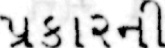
પ્રકારની
